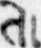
તો
